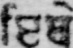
ਇਥੇ
